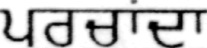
ਪਰਚਾਂਦਾ
